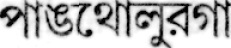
পাঙথোকলুরগা
